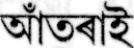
আঁতৰাই
